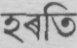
হৰতি
